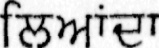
ਲਿਆਂਦਾ
